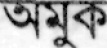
অমুক
